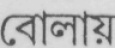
বোলায়
